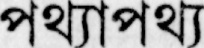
পথ্যাপথ্য
